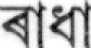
ৰাধা
